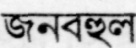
জনবহুল
